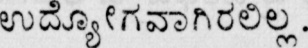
ಉದ್ಯೋಗವಾಗಿರಲಿಲ್ಲ.
